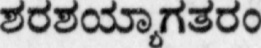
ಶರಶಯ್ಯಾಗತರಂ
